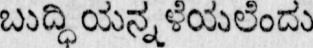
ಬುದ್ಧಿಯನ್ನಳೆಯಲೆಂದು
